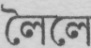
লৈলে
